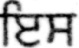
ਇਸ
